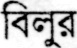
বিলুর
